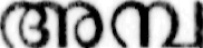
അമ്പ
